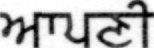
ਆਪਣੀ
